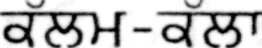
ਕੱਲਮ-ਕੱਲਾ
